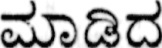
ಮಾಡಿದ
